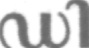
ഡി
